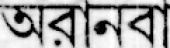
অরানবা
